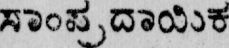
ಸಾಂಪ್ರದಾಯಿಕ
